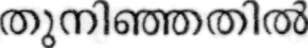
തുനിഞ്ഞതില്‍
